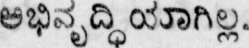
ಅಭಿವೃದ್ಧಿಯಾಗಿಲ್ಲ.
